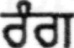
ਰੰਗ
